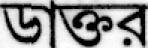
ডাক্তর
